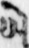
એ
